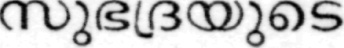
സുഭദ്രയുടെ
